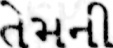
તેમની
